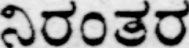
ನಿರಂತರ
